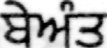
ਬੇਅੰਤ
